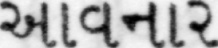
આવનાર
